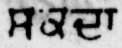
ਸਕਦਾ
